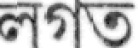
লগত
